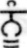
ਨੂੰ
